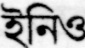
ইনিও
